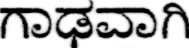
ಗಾಢವಾಗಿ
